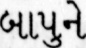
બાપુને
